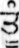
ਤੂੰ
